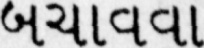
બચાવવા
